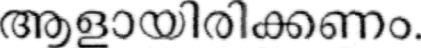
ആളായിരിക്കണം.
